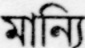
মান্যি
